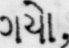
ગયો,
